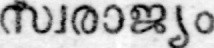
സ്വരാജ്യം
